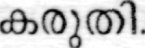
കരുതി.
